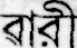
ৱারী
